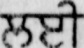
ਲਈ
